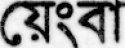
য়েংবা
